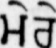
ਮੇਰੇ
